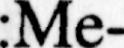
:Me-
